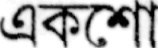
একশো
